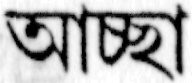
আচ্ছা
